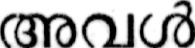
അവള്‍
